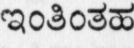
ಇಂತಿಂತಹ
